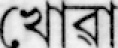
খোৱা
